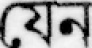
যেন
